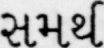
સમર્થ
